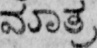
ಮಾತ್ರ
